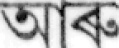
আৰু
